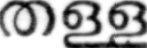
തള്ള
